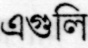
এগুলি
